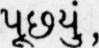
પૂછયું,
